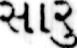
સારું
